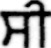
ਸੀ
